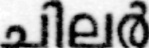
ചിലര്‍
